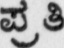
ಪ್ರತಿ
